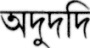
অদুদদি
